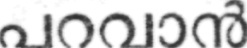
പറവാന്‍
